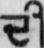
ਦੀ
